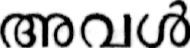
അവള്‍
